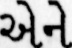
એને
